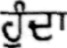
ਹੁੰਦਾ
